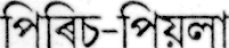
পিৰিচ-পিয়লা
